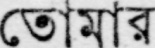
তোমার
